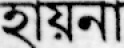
হায়না
